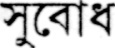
সুবোধ
